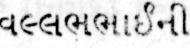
વલ્લભભાઈની
